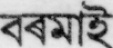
বৰমাই
